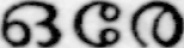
ഒരേ
